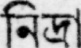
নিদ্রা
